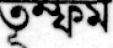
তূম্ফম
